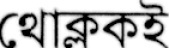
থোক্লকই
